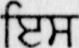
ਇਸ
